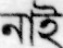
নাই
